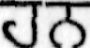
ਹਨ
